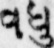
વધુ
